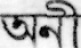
অনী
